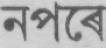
নপৰে
